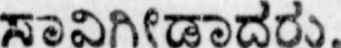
ಸಾವಿಗೀಡಾದರು.
